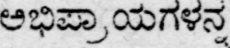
ಅಭಿಪ್ರಾಯಗಳನ್ನು
